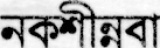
নকশীন্নবা
